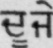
ਦੂਜੇ
